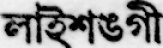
লাইশঙগী
